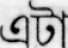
এটা
